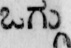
ಒಗ್ಗು
